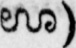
ಊ)
